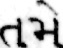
તમે
